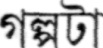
গল্পটা
